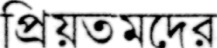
প্রিয়তমদের
